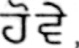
ਹੋਵੇ,
